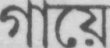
গায়ে
